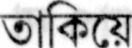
তাকিয়ে
